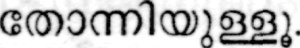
തോന്നിയുള്ളൂ.
